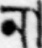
না
